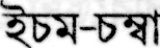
ইচম-চম্বা
